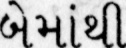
બેમાંથી
